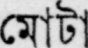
মোটা
